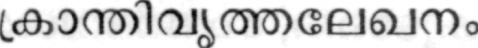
ക്രാന്തിവൃത്തലേഖനം
